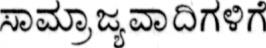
ಸಾಮ್ರಾಜ್ಯವಾದಿಗಳಿಗೆ
